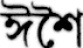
ঈশৈ
